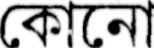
কোনো
